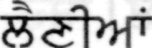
ਲੈਣੀਆਂ
